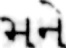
મને
